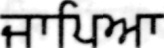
ਜਾਪਿਆ
